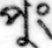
পুং
